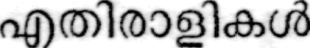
എതിരാളികള്‍
